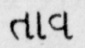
તાવ
